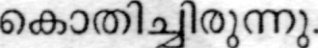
കൊതിച്ചിരുന്നു.
